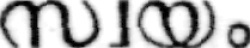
സ്വയം
